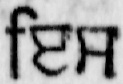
ਇਸ
